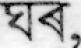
ঘৰ,
